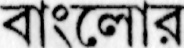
বাংলোর
